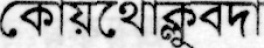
কোয়থোক্লুবদা
